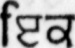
ਇਕ
